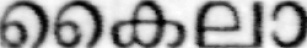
കൈലാ
